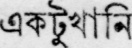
একটুখানি
